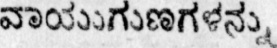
ವಾಯುಗುಣಗಳನ್ನು
